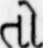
તો
